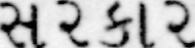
સરકાર
